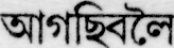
আগছিবলৈ
